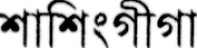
শাশিংগীগা
